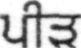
ਪੀੜ
